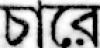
চারে
